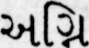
અગ્નિ
